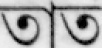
তাত
